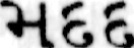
મદદ
